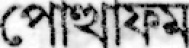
পোত্থাফম
